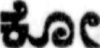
ಕೋ
